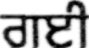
ਗਈ
